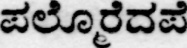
ಪಲ್ಮೊರೆದಪೆ
